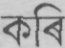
কৰি
